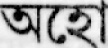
অহো
